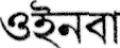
ওইনবা
